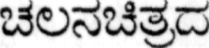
ಚಲನಚಿತ್ರದ
